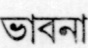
ভাবনা
